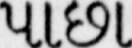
પાછા
